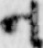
ન
